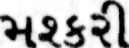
મશ્કરી
